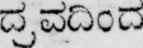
ದ್ರವದಿಂದ
